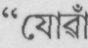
"যোৱাঁ
